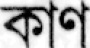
কাণ
